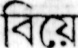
বিয়ে
